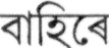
বাহিৰে
